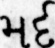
મર્દ
